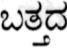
ಬತ್ತದ
